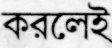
করলেই
